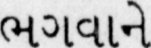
ભગવાને
